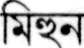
মিহুন
